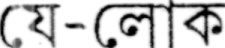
যে-লোক
